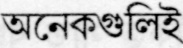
অনেকগুলিই
